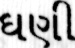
ઘણી
